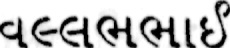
વલ્લભભાઈ
